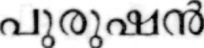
പുരുഷന്‍
